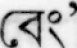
বেং'
